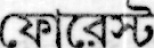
ফোরেস্ট
